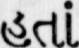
હતાં
